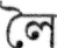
লৈ
